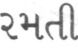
રમતી
